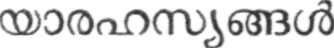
യാരഹസ്യങ്ങള്‍
